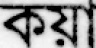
কয়া
